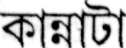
কান্নাটা
